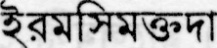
ইরমসিমক্তদা
